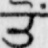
ਤੋਂ
